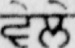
ਵੇਲੇ
